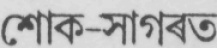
শোক-সাগৰত
